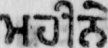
ਮਹੀਨੇ
